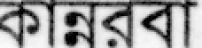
কান্নরবা
